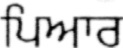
ਪਿਆਰ
